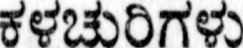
ಕಳಚುರಿಗಳು
